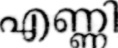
എണ്ണി
